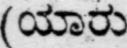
(ಯಾರು
